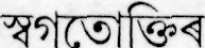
স্বগতোক্তিৰ
